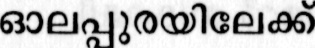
ഓലപ്പുരയിലേക്ക്
